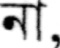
না,
